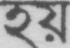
হয়
